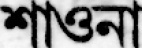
শাওনা
